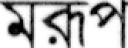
মরূপ
